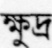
ক্ষুদ্র
